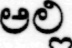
ಅಲ್ಲಿ
